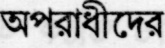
অপরাধীদের
